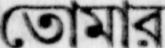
তোমার
